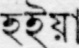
হইয়া
